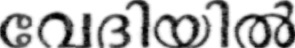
വേദിയില്‍
